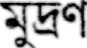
মুদ্রণ
